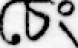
চেং
